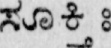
ಸೂಕ್ತಿಃ
